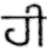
ਹੀ
